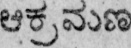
ಆಕ್ರಮಣ
